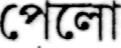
পেলো
